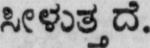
ಸೀಳುತ್ತದೆ.
